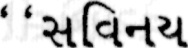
"સવિનય
